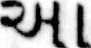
આ
